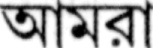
আমরা
